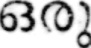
ഒരു
